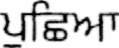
ਪੁਛਿਆ
